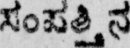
ಸಂಪತ್ತಿನ
